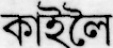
কাইলৈ
